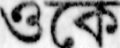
ওকে
